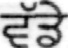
ਵੱਡੇ
